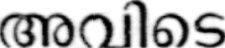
അവിടെ
